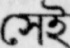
সেই
